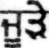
ਜੂੜੇ
